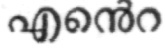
എന്റെ
